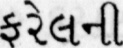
ફરેલની
